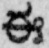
ಈ
